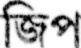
জিপ
